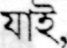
যাই,
